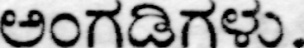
ಅಂಗಡಿಗಳು.
